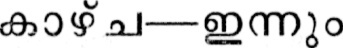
കാഴ്ച-ഇന്നും
